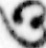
ও
